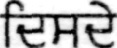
ਦਿਸਦੇ
